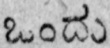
ಒಂದು
